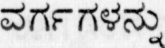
ವರ್ಗಗಳನ್ನು
